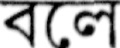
বলে
